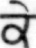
ਕੇ
